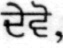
ਦੇਵੋ,
